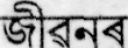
জীৱনৰ
